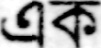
এক
